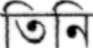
তিনি
